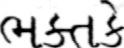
ભક્તકે
